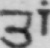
ਤਾਂ
